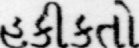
હકીકતો
